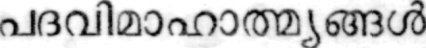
പദവിമാഹാത്മ്യങ്ങള്‍
